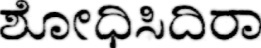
ಶೋಧಿಸಿದಿರಾ
